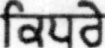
ਕਿਧਰੇ
